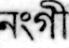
নংগী
